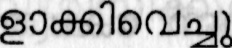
ളാക്കിവെച്ചു
